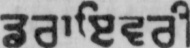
ਡਰਾਇਵਰੀ
